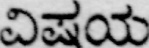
ವಿಷಯ
